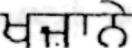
ਖਜ਼ਾਨੇ
